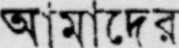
আমাদের
